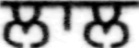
ਲਾਲ
